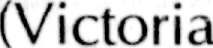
(Victoria
